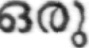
ഒരു
